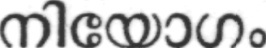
നിയോഗം
